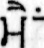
ਮੈਂ
